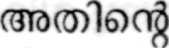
അതിന്റെ
